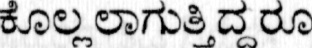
ಕೊಲ್ಲಲಾಗುತ್ತಿದ್ದರೂ
